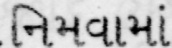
નિમવામાં
